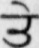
ਤੇ
